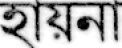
হায়না
